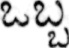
ಒಬ್ಬ
